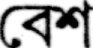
বেশ
